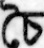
চৈ
